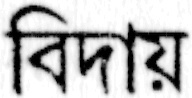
বিদায়
